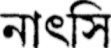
নাৎসি
